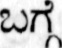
ಬಗ್ಗೆ
